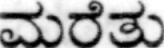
ಮರೆತು
